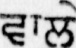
ਵਾਲੇ
